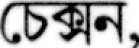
চেক্সন,
